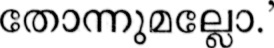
തോന്നുമല്ലോ.’
